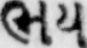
ભય
